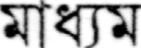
মাধ্যম
